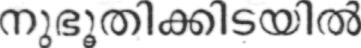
നുഭൂതിക്കിടയില്‍
